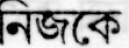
নিজকে
